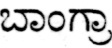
ಬಾಂಗ್ರಾ
